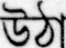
উঠা
